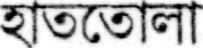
হাততোলা
